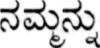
ನಮ್ಮನ್ನು
